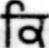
ਕਿ
